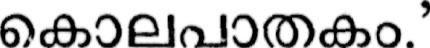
കൊലപാതകം.’
